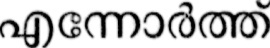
എന്നോര്‍ത്ത്
